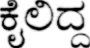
ಕೈಲಿದ್ದ
